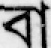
বা
